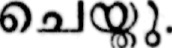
ചെയ്തു.
